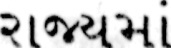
રાજ્યમાં
